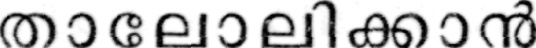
താലോലിക്കാന്‍
